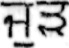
ਜੁੜ
